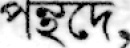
পন্থদে,
